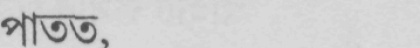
পাতত,
